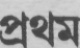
প্ৰথম
